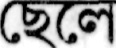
ছেলে
